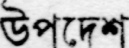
উপদেশ
